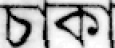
চাকা
